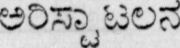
ಅರಿಸ್ಟಾಟಲನ
